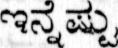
ಇನ್ನೆಷ್ಟು
